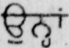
ਉਨ੍ਹਾਂ
